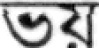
ভয়
